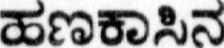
ಹಣಕಾಸಿನ
